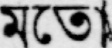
মতো
